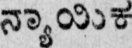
ನ್ಯಾಯಿಕ
